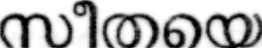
സീതയെ
